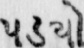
પડ્યો
